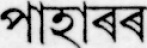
পাহাৰৰ
